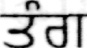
ਤੰਗ
